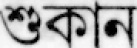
শুকান
